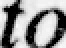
to
